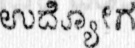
ಉದ್ಯೋಗ
